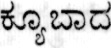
ಕ್ಯೂಬಾದ
